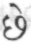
છે
